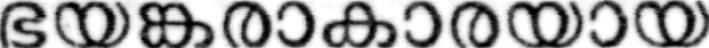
ഭയങ്കരാകാരയായ
